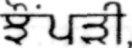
ਝੌਂਪੜੀ,
